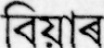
বিয়াৰ
